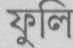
ফুলি
